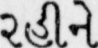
રહીને
